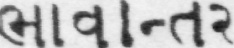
ભાવાન્તર
